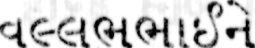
વલ્લભભાઈને
